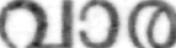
വാര
